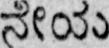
ನೇಯ
